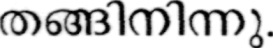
തങ്ങിനിന്നു.
